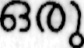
ഒരു
